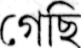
গেছি
